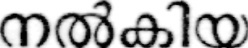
നല്‍കിയ
